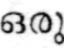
ഒരു
